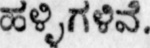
ಹಳ್ಳಿಗಳಿವೆ.
